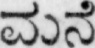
ಮನೆ
